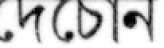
দেচোন
